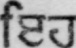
ਇਹ
